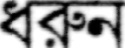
ধরুন
